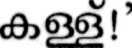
കള്ള്!’
